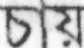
চায়
